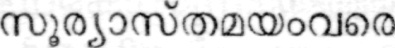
സൂര്യാസ്തമയംവരെ
